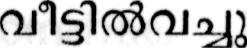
വീട്ടില്‍വച്ചു
